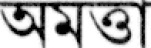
অমত্তা
